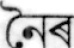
নৈৰ
